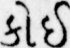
કોઈ
